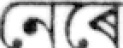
নেৰে
